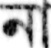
না
